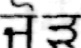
ਜੋੜ
